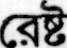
রেষ্ট
